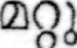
മറ്റു
